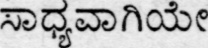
ಸಾಧ್ಯವಾಗಿಯೇ
